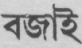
বজাই
